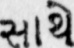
સાથે
